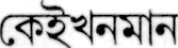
কেইখনমান
